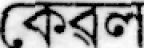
কেৱল
